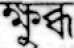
ক্ষুব্ধ
